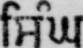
ਸਿੰਘ
